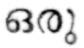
ഒരു
